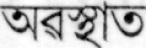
অৱস্থাত
